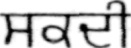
ਸਕਦੀ
